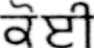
ਕੋਈ
